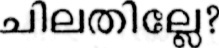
ചിലതില്ലേ?
